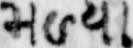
મળ્યા
